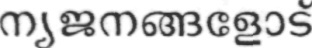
ന്യജനങ്ങളോട്
